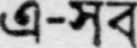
এ-সব
